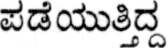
ಪಡೆಯುತ್ತಿದ್ದ
